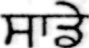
ਸਾਡੇ
